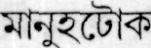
মানুহটোক
